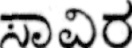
ಸಾವಿರ
